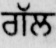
ਗੱਲ
